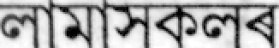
লামাসকলৰ
